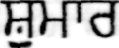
ਸ਼ੁਮਾਰ
